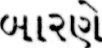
બારણે
